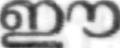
ഈ
